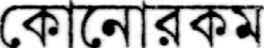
কোনোরকম
